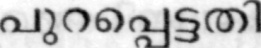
പുറപ്പെട്ടതി
